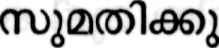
സുമതിക്കു
